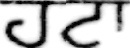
ਹਟਾ
